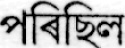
পৰিছিল
